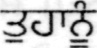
ਤੁਹਾਨੂੰ
